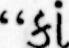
"કાં
